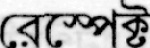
রেস্পেক্ট
